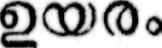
ഉയരം
